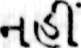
નહીં
